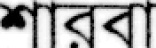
শারবা
